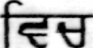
ਵਿਚ
